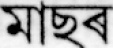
মাছৰ
